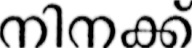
നിനക്ക്
